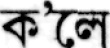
ক'লে
